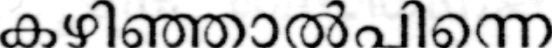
കഴിഞ്ഞാല്‍പിന്നെ
